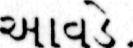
આવડે.
